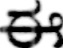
ಈ
